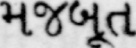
મજબૂત
